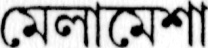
মেলামেশা
